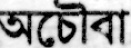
অচৌবা
